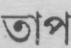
তাপ
